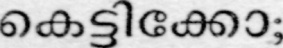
കെട്ടിക്കോ;
